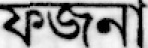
ফজনা
